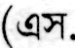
(এস.
